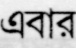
এবার
